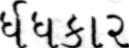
ર્ધધકાર
